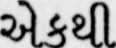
એકથી
